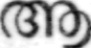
ആ
